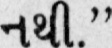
નથી."
